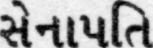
સેનાપતિ
